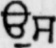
ਉਸ
